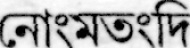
নোংমতংদি
